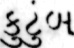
કુટુંબ
